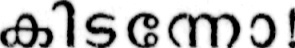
കിടന്നോ!
